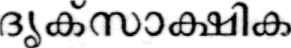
ദൃക്സാക്ഷിക
